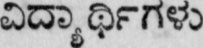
ವಿದ್ಯಾರ್ಥಿಗಳು
